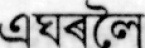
এঘৰলৈ
